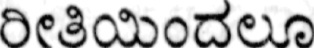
ರೀತಿಯಿಂದಲೂ
